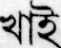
খাই
